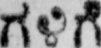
ಗಳಿಗೆ
